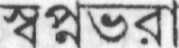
স্বপ্নভরা
